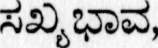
ಸಖ್ಯಭಾವ,
